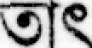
তাৎ
